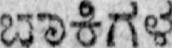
ಬಾಕಿಗಳ
